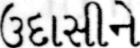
ઉદાસીને
